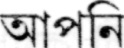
আপনি
